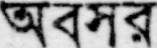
অবসর
